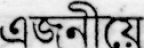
এজনীয়ে
